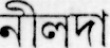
নীলদা
